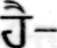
ਹੈ-
